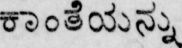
ಕಾಂತೆಯನ್ನು
